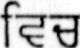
ਵਿਚ
